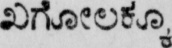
ಖಗೋಲಕ್ಕೂ
